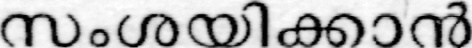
സംശയിക്കാന്‍
